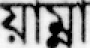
য়াম্না
